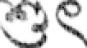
শুৎ
